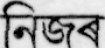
নিজৰ
